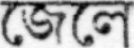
জেলে
